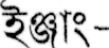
ইঞ্জাং-
